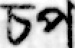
চপ
